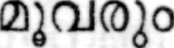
മൂവരും
